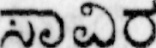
ಸಾವಿರ
